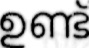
ഉണ്ട്
